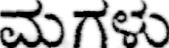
ಮಗಳು
